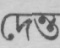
দেন্ত
